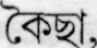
কৈছা,
